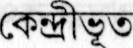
কেন্দ্রীভূত
